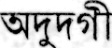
অদুদগী
